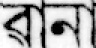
ৱানা
